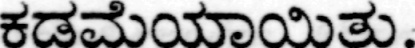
ಕಡಮೆಯಾಯಿತು.
